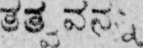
ತತ್ವವನ್ನು
